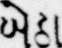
બેઠા
